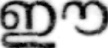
ഈ
